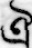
ঐ
